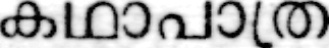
കഥാപാത്ര
